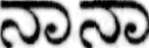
ನಾನಾ
